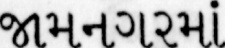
જામનગરમાં
